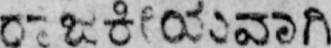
ರಾಜಕೀಯವಾಗಿ
